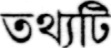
তথ্যটি
